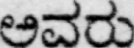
ಅವರು
